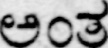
ಅಂತ
